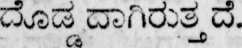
ದೊಡ್ಡದಾಗಿರುತ್ತದೆ.
